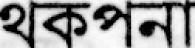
থকপনা
